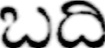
ಬದಿ
